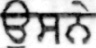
ਉਸਨੇ
